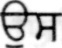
ਉਸ
